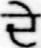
ਦੇ
